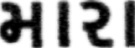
મારા
